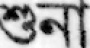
শুনা
